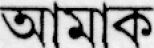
আমাক
